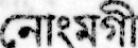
নোংমগী
